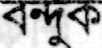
বন্দুক
